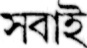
সবাই
